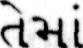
તેમાં
